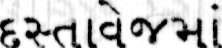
દસ્તાવેજમાં
